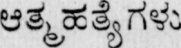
ಆತ್ಮಹತ್ಯೆಗಳು
